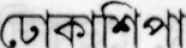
ঢোকাশিপা
